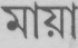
মায়া
